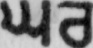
ਘਰ
